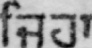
ਜਿਹਾ
